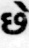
છે
